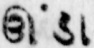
ઊંડા
